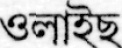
ওলাইছ
